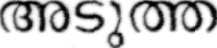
അടുത്ത
